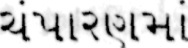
ચંપારણમાં
